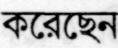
করেছেন
